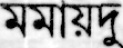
মমায়দু
